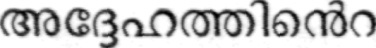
അദ്ദേഹത്തിന്റെ
